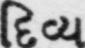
દિવ્ય
